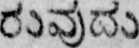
ರುವುದು
